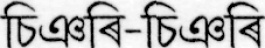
চিঞৰি-চিঞৰি
